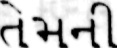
તેમની
